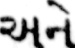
અને
